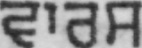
ਵਾਰਸ
